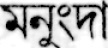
মনুংদা
